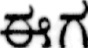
ಈಗ
